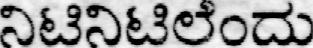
ನಿಟಿನಿಟಿಲೆಂದು
